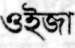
ওইজা
